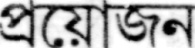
প্রয়োজন
